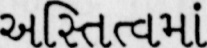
અસ્તિત્વમાં
